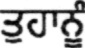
ਤੁਹਾਨੂੰ
